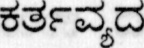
ಕರ್ತವ್ಯದ
